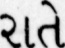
રાતે
